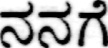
ನನಗೆ
